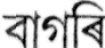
বাগৰি
